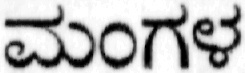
ಮಂಗಳ
